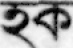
হক
